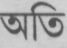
অতি
